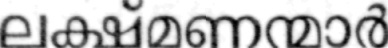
ലക്ഷ്മണന്മാര്‍
